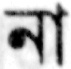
না
